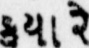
ક્યારે
